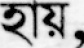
হায়,
